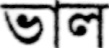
ভাল
